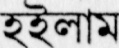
হইলাম
